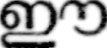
ഈ
